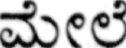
ಮೇಲೆ
